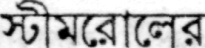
স্টীমরোলের
